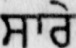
ਸਾਰੇ
